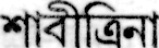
শাবীত্রিনা
